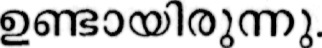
ഉണ്ടായിരുന്നു.
